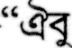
“ঐবু
